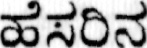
ಹೆಸರಿನ
